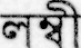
লম্বী
